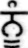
ਨੂੰ
